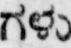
ಗಳು
